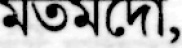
মতমদো,
